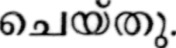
ചെയ്തു.
